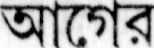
আগের
